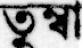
তুম্বা
